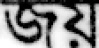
জয়
